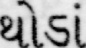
થોડાં
